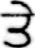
ਤੇ
